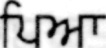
ਪਿਆ
